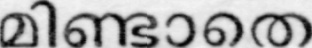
മിണ്ടാതെ
